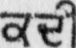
ਕਦੀ
